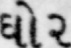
ઘોર
